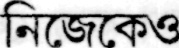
নিজেকেও
